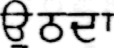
ਉਠਦਾ
